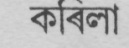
কৰিলা
